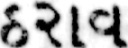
ઠરાવ
